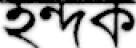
হন্দক
